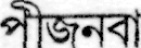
পীজনবা
